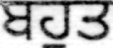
ਬਹੁਤ
